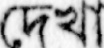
দেখা
